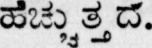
ಹೆಚ್ಚುತ್ತದೆ.
